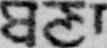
ਬਣਾ
